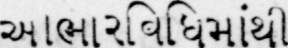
આભારવિધિમાંથી
